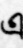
এ
